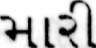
મારી
